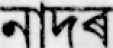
নাদৰ
